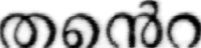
തന്റെ
